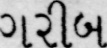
ગરીબ
